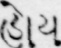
હોય
